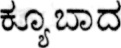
ಕ್ಯೂಬಾದ
